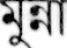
মুন্না
